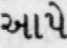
આપે
